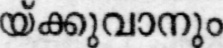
യ്ക്കുവാനും
